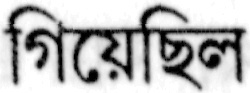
গিয়েছিল
